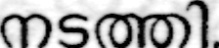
നടത്തി.
